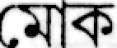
মোক
